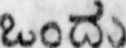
ಒಂದು
